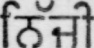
ਨਿੱਜੀ
